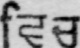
ਵਿਚ
